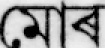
মোৰ
